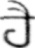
ਹੈ
